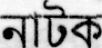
নাটক
